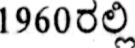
1960ರಲ್ಲಿ
